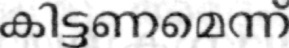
കിട്ടണമെന്ന്
